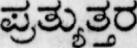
ಪ್ರತ್ಯುತ್ತರ
